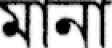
মানা
